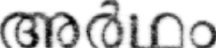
അര്‍ഥം
